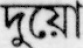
দুয়ো
